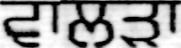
ਵਾਲੜਾ
